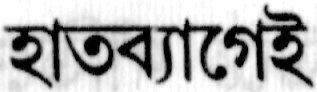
হাতব্যাগেই
